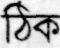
ঠিক
